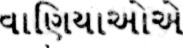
વાણિયાઓએ
